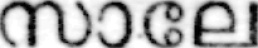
സാലേ
